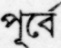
পূর্বে
